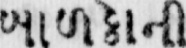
બાળકોની
